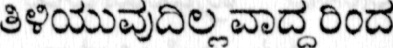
ತಿಳಿಯುವುದಿಲ್ಲವಾದ್ದರಿಂದ
